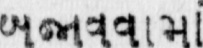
બજાવવામાં
